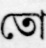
তো
